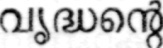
വൃദ്ധന്റെ
